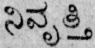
ನಿವೃತ್ತಿ
